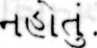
નહોતું.
